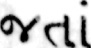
જતાં
